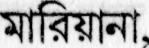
মারিয়ানা,
